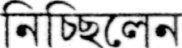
নিচ্ছিলেন
